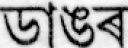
ডাঙৰ
